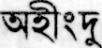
অহীংদু
